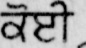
ਕੋਈ
